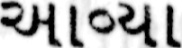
આવ્યા
